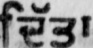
ਦਿੱਤਾ
